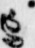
હું
